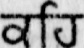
ਕਹਿ
